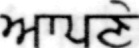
ਆਪਣੇ
